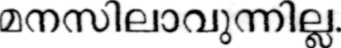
മനസിലാവുന്നില്ല.
